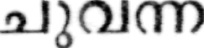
ചുവന്ന
